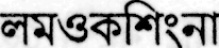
লমওকশিংনা
